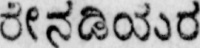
ರೇನಡಿಯರ
